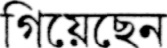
গিয়েছেন
